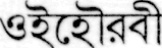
ওইহৌরবী
